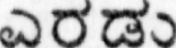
ಎರಡು
